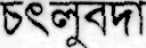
চৎলুবদা
